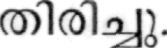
തിരിച്ചു.
